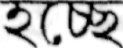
হচ্ছে
